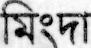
মিংদা
